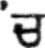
'ਚ
